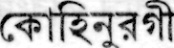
কোহিনুরগী
